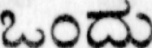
ಒಂದು
